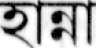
হান্না
